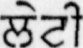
ਲੇਟੀ
